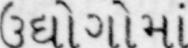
ઉદ્યોગોમાં
